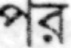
পর
